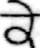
ਕੇ
